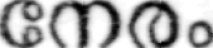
നേരം
